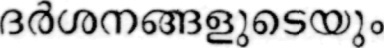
ദര്‍ശനങ്ങളുടെയും
